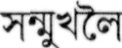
সন্মুখলৈ
